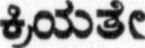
ಕ್ರಿಯತೇ
